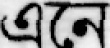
এনে
